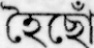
হৈছোঁ
